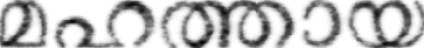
മഹത്തായ
